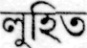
লুহিত
